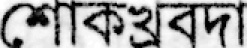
শোকখ্রবদা
